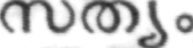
സത്യം
